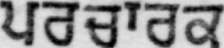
ਪਰਚਾਰਕ
